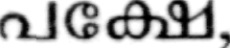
പക്ഷേ,
